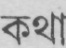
কথা
